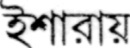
ইশারায়
